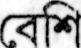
বেশি
